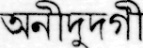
অনীদুদগী
